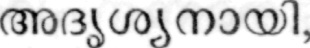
അദൃശ്യനായി,
